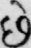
છે
